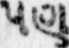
પણ
